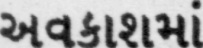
અવકાશમાં
